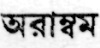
অরাম্বম
